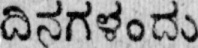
ದಿನಗಳಂದು
